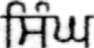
ਸਿੰਘ
